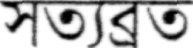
সত্যব্রত
